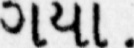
ગયા.
